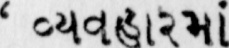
'વ્યવહારમાં
